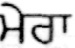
ਮੇਰਾ
